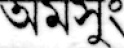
অমসুং
